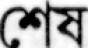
শেষ
